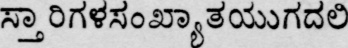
ಸ್ತಾರಿಗಳಸಂಖ್ಯಾತಯುಗದಲಿ
